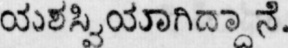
ಯಶಸ್ವಿಯಾಗಿದ್ದಾನೆ.
